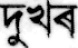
দুখৰ
